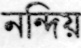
নন্দিয়
